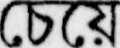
চেয়ে
